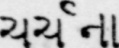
ચર્ચના
